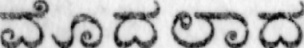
ಮೊದಲಾದ
